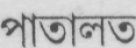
পাতালত
